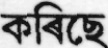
কৰিছে
